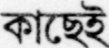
কাছেই
